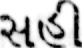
સહી
